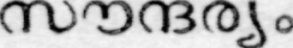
സൌന്ദര്യം
